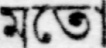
মতো
